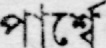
পার্শ্বে
